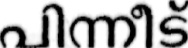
പിന്നീട്
